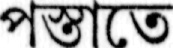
পস্তাতে
